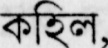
কহিল,
